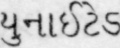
યુનાઈટેડ
